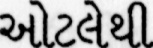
ઓટલેથી
